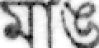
মাঙ
